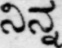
ನಿನ್ನ
